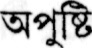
অপুষ্টি
